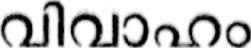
വിവാഹം
